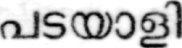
പടയാളി
